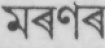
মৰণৰ
